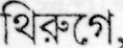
থিরুগে,
